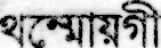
থম্মোয়গী
